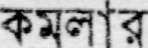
কমলার
